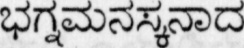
ಭಗ್ನಮನಸ್ಕನಾದ
